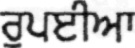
ਰੁਪਈਆ
